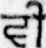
ਵੀ
